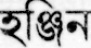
হঞ্জিন
